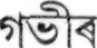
গভীৰ
